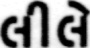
લીલે
